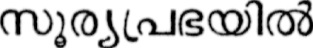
സൂര്യപ്രഭയില്‍
